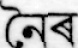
নৈৰ
